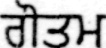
ਗੌਤਮ
